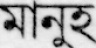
মানুহ
